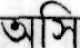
অসি
